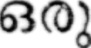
ഒരു
